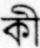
কী
